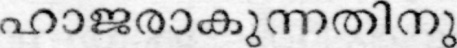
ഹാജരാകുന്നതിനു
